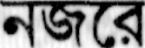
নজরে
